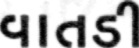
વાતડી
